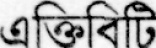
এক্টিবিটি
